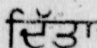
ਦਿੱਤਾ
